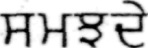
ਸਮਝਦੇ
